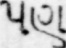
પણ
